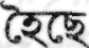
হৈছে
